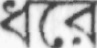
ধরে
